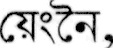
য়েংনৈ,
